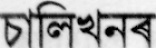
চালিখনৰ
